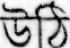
উঠি
